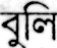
বুলি
